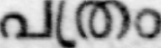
പത്രം
